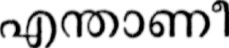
എന്താണീ
